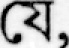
যে,
